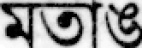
মতাঙ
